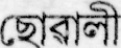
ছোৱালী
